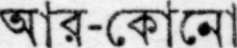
আর-কোনো
